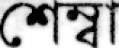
শেম্বা
